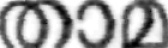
താമ
